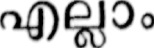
എല്ലാം
